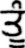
ਤੂੰ
